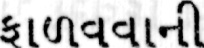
ફાળવવાની
